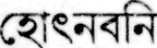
হোৎনবনি
